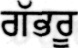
ਗੱਭਰੂ
